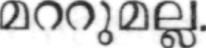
മററുമല്ല.
